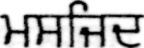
ਮਸਜਿਦ
